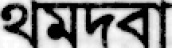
থমদবা
